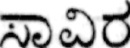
ಸಾವಿರ
